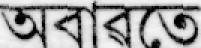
অবাৱতে
